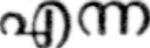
എന്ന
